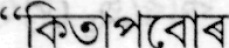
"কিতাপবোৰ
